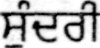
ਸੁੰਦਰੀ
